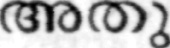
അതു
